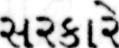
સરકારે
